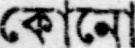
কোনো
